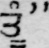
ਤੂੰ''
